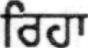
ਰਿਹਾ
